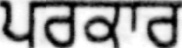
ਪਰਕਾਰ
